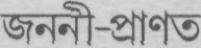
জননী-প্ৰাণত
